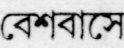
বেশবাসে
